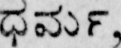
ಧರ್ಮ,
